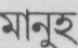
মানুহ
